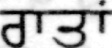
ਰਾਤਾਂ
